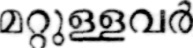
മറ്റുള്ളവര്‍
